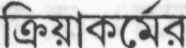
ক্রিয়াকর্মের
